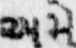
અમે
